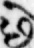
છે
